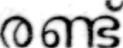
രണ്ട്
